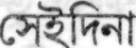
সেইদিনা
